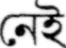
নেই
